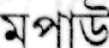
মপাউ
